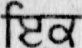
ਇਕ
